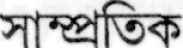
সাম্প্রতিক
